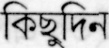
কিছুদিন
